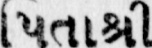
પિતાશ્રી
